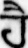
ਹੈ
